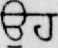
ਉਹ
